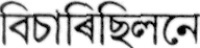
বিচাৰিছিলনে
